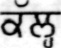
ਕੱਲ੍ਹ
